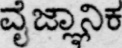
ವೈಜ್ಞಾನಿಕ
